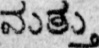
ಮತ್ತು
